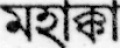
মহাক্কা
